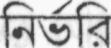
নির্ভরি
